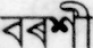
বৰশী
